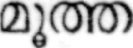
മൂത്ത
